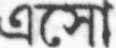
এসো
